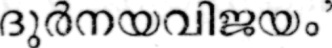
ദുര്‍നയവിജയം'
